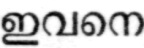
ഇവനെ
